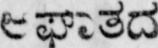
ಆಘಾತದ
